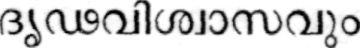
ദൃഢവിശ്വാസവും
